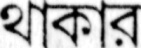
থাকার
